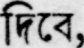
দিবে,
